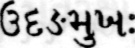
ઉદઙમુખઃ
